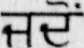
ਜਦੋਂ
